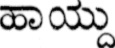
ಹಾಯ್ದು
